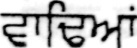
ਵਾਢਿਆਂ
